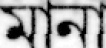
মানা
